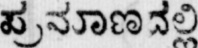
ಪ್ರಮಾಣದಲ್ಲಿ
